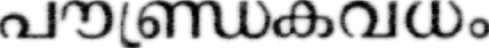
പൌണ്ഡ്രകവധം
